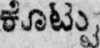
ಕೊಟ್ಟು
